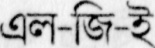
এল-জি-ই
